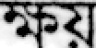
ক্ষয়
